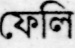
ফেলি
